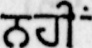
ਨਹੀਂ
